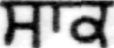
ਸਾਕ
